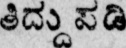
ತಿದ್ದುಪಡಿ
